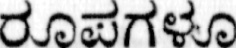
ರೂಪಗಳೂ
